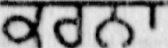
ਕਰਨਾ
